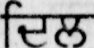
ਦਿਲ
